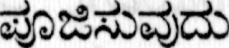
ಪೂಜಿಸುವುದು
